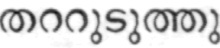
തററുടുത്തു
